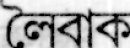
লৈবাক
